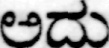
ಅದು
